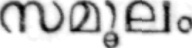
സമൂലം
